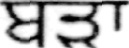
ਬੜਾ
